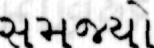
સમજ્યો
